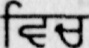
ਵਿਚ
